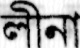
লীনা
